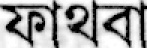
ফাথবা
